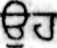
ਉਹ
